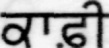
ਕਾਫ਼ੀ
